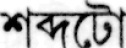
শব্দটো
